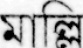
মাল্লি
